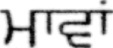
ਮਾਵਾਂ
